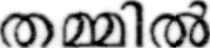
തമ്മില്‍
